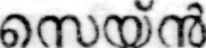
സെയ്ന്‍
